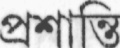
প্রশান্তি
